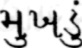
મુખડું
